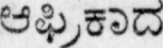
ಆಫ್ರಿಕಾದ
